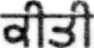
ਕੀਤੀ
